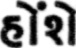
હોંશે
